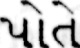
પોતે
